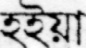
হইয়া
